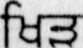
ਖਿੜ
